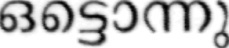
ഒട്ടൊന്നു
